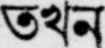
তখন
